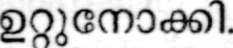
ഉറ്റുനോക്കി.
